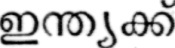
ഇന്ത്യക്ക്
